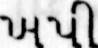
ખપી
